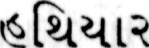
હથિયાર
